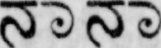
ನಾನಾ
